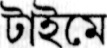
টাইমে
